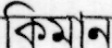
কিমান
